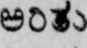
ಅರಿತು
